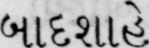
બાદશાહે
